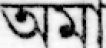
অমা
